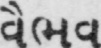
વૈભવ
